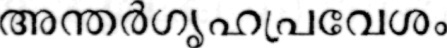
അന്തര്‍ഗൃഹപ്രവേശം
